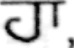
ਹਾਂ,
